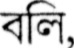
বলি,
